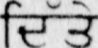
ਦਿੱਤੇ
